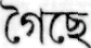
গৈছে
